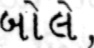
બોલે,
